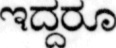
ಇದ್ದರೂ
